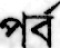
পর্ব
